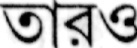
তারও
